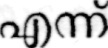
എന്ന്
